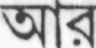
আর
